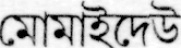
মোমাইদেউ
